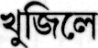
খুজিলে
